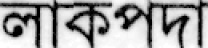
লাকপদা
